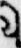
યે
